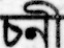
চনী
